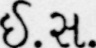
ઈ.સ.
